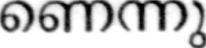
ണെന്നു
